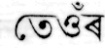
তেওঁৰ
